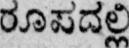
ರೂಪದಲ್ಲಿ
